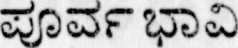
ಪೂರ್ವಭಾವಿ
